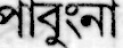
পাবুংনা
